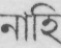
নাহি
